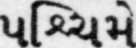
પશ્ચિમે
